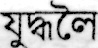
যুদ্ধলৈ
